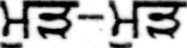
ਮੁੜ-ਮੁੜ
